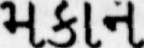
મકાન
